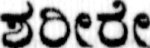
ಶರೀರೇ
